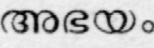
അഭയം
